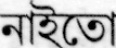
নাইতো
